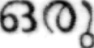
ഒരു
